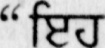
''ਇਹ
